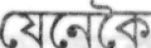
যেনেকৈ
